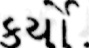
કર્યો.
